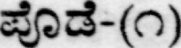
ಪೊಡೆ-(೧)
